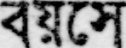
বয়সে
